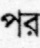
পর
